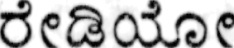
ರೇಡಿಯೋ
